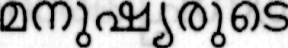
മനുഷ്യരുടെ
